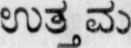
ಉತ್ತಮ
